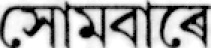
সোমবাৰে
